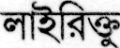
লাইরিক্তু
